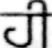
ਹੀ
